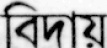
বিদায়
